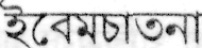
ইবেমচানা
